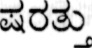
ಷರತ್ತು
